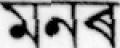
মনৰ
